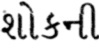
શોકની
